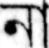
না
